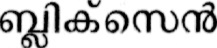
ബ്ലിക്സെന്‍
